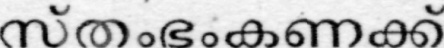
സ്തംഭംകണക്ക്
